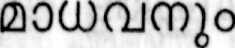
മാധവനും
